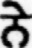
ਨੇ
